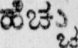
ಹೆಚ್ಚು
